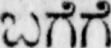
ಬಗೆಗೆ
